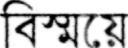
বিস্ময়ে
